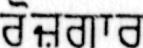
ਰੋਜ਼ਗਾਰ
